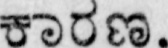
ಕಾರಣ.
